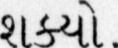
શક્યો.
